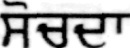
ਸੋਚਦਾ
